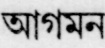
আগমন
